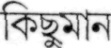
কিছুমান
